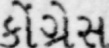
કોંગ્રેસ
